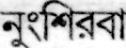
নুংশিরবা
